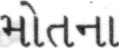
મોતના
